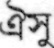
ঐসু
